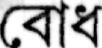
বোধ
